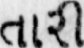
તારી
